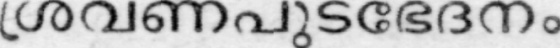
ശ്രവണപുടഭേദനം
